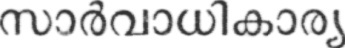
സാര്‍വാധികാര്യ
